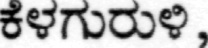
ಕೆಳಗುರುಳಿ,
